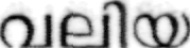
വലിയ
